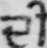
ਦੀ
